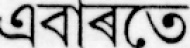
এবাৰতে
